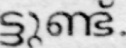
ട്ടുണ്ട്.
